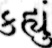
ક્હ્યું
